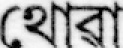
থোৱা
